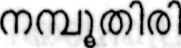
നമ്പൂതിരി
